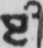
ਈ
